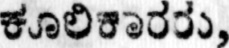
ಕೂಲಿಕಾರರು,
